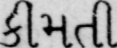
કીંમતી
